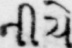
નીચે
